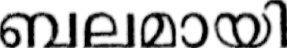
ബലമായി
